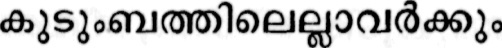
കുടുംബത്തിലെല്ലാവര്‍ക്കും
